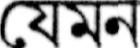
যেমন
